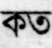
কত
